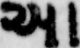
આ
